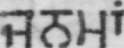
ਜਨਮਾਂ
